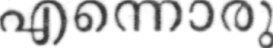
എന്നൊരു
